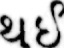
થઈ
